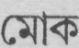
মোক
